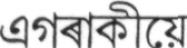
এগৰাকীয়ে
